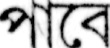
পাবে
